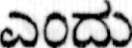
ಎಂದು
